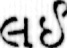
લઈ
